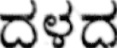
ದಳದ
